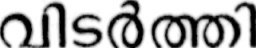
വിടര്‍ത്തി
